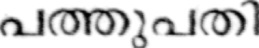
പത്തുപതി
